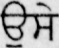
ਉਸੇ
